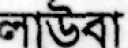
লাউবা
